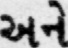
અને
